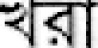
খরা
